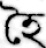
হৈ
